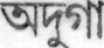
অদুগা
